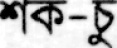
শক-চু
